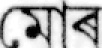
মোৰ
